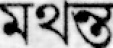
মথন্তা
